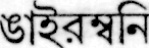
ঙাইরম্বনি
